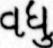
વધુ
